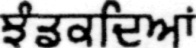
ਝੰਡਕਦਿਆਂ
